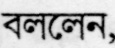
বললেন,
